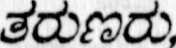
ತರುಣರು,
